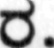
ರ.
